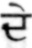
ਦੇ
